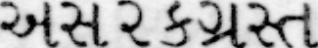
અસરકગ્રસ્ત
